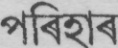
পৰিহাৰ
